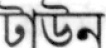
টাউন
